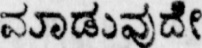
ಮಾಡುವುದೇ
